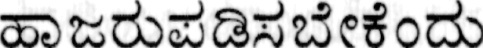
ಹಾಜರುಪಡಿಸಬೇಕೆಂದು
